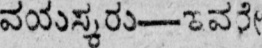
ವಯಸ್ಕರು-ಇವರೇ
